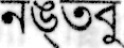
নঙ্তবু
